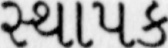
સ્થાપક
